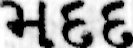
મદદ
